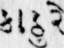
કાઠુરે
